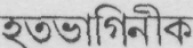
হতভাগিনীক
